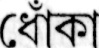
ধোঁকা
